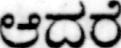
ಆದರೆ
